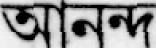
আনন্দ
